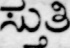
ಸ್ತುತಿ
